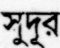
সুদূর
